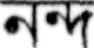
নন্দ
